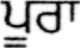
ਪੂਰਾ
